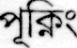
পূ্ক্নিং
